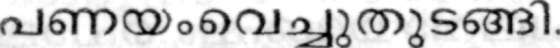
പണയംവെച്ചുതുടങ്ങി.
